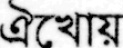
ঐখোয়
